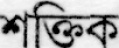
শক্তিক
